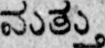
ಮತ್ತು
